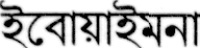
ইবোয়াইমনা
